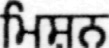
ਮਿਸ਼ਨ
